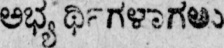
ಅಭ್ಯರ್ಥಿಗಳಾಗಲು
